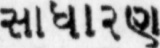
સાધારણ
